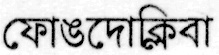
ফোঙদোক্লিবা
